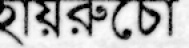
হায়রুচো
